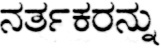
ನರ್ತಕರನ್ನು
